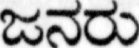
ಜನರು
